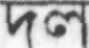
দল
